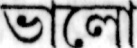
ভালো
